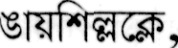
ঙায়শিল্লক্লে,
